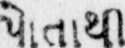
પોતાથી
